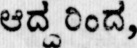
ಆದ್ದರಿಂದ,
